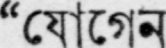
‘‘যোগেন
